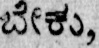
ಬೇಕು,
